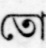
তো
